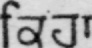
ਕਿਹਾ
